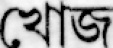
খোজ
